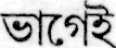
ভাগেই
